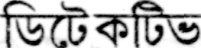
ডিটেকটিভ
